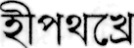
হীপথখ্রে
